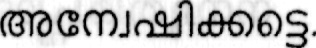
അന്വേഷിക്കട്ടെ.
